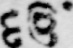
દઉં
